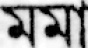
মমা
